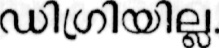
ഡിഗ്രിയില്ല.
